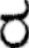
ರ
